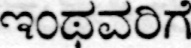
ಇಂಥವರಿಗೆ
